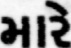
મારે
